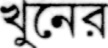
খুনের
